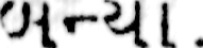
બન્યા.
